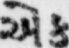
એક
